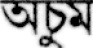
অচুম
